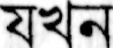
যখন
